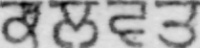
ਕਲਵਤ
